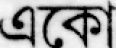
একো
